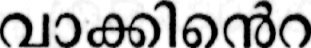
വാക്കിന്റെ
